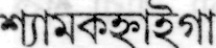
শ্যামকহ্ণাইগা
